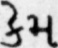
કેમ
